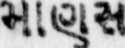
માણસ
